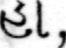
હા,
